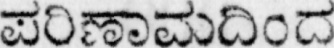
ಪರಿಣಾಮದಿಂದ
